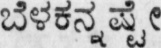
ಬೆಳಕನ್ನಷ್ಟೇ
